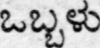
ಒಬ್ಬಳು
